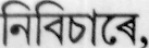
নিবিচাৰে,
